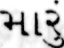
મારું
